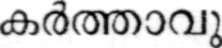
കര്‍ത്താവു
